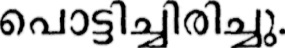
പൊട്ടിച്ചിരിച്ചു.
